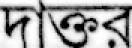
দাক্তর
